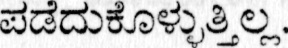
ಪಡೆದುಕೊಳ್ಳುತ್ತಿಲ್ಲ.
